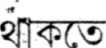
থাকতে
